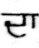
ਦਾ
